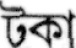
টকা
